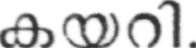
കയറി.
